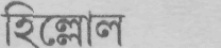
হিল্লোল
